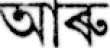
আৰু
